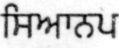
ਸਿਆਨਪ
